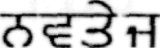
ਨਵਤੇਜ
